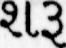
શરૂ
